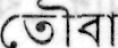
তৌবা
